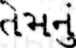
તેમનું
